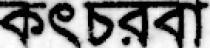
কৎচরবা
